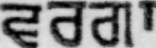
ਵਰਗਾ
